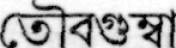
তৌবগুম
